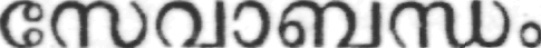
സേവാബന്ധം
